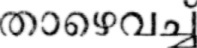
താഴെവച്ച്
